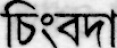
চিংবদা
